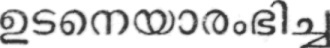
ഉടനെയാരംഭിച്ച
